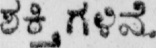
ಶಕ್ತಿಗಳಿವೆ.
